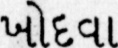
ખોદવા
